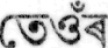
তেওঁৰ
